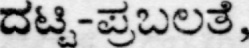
ದಟ್ಟಿ-ಪ್ರಬಲತೆ,
